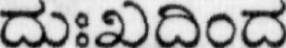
ದುಃಖದಿಂದ
